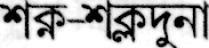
শক্ল-শক্লদুনা
